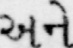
અને
